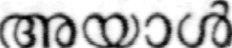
അയാള്‍
